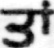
ਤਾਂ
